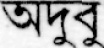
অদুবু
